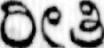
ರೀತಿ
